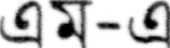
এম-এ
